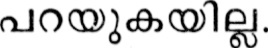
പറയുകയില്ല.
